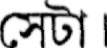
সেটা।
